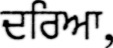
ਦਰਿਆ,
